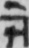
ਜੇ
